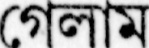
গেলাম
